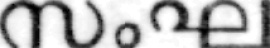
സംഘ
